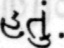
હતું.
